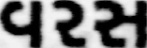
વરસ
